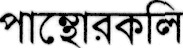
পান্থোরকলি
